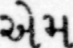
એમ
